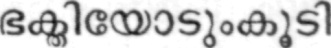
ഭക്തിയോടുംകൂടി
